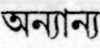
অন্যান্য
